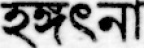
হঙ্গৎনা
